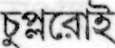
চুপ্লরোই
